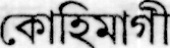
কোহিমাগী
